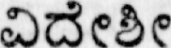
ವಿದೇಶೀ
